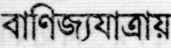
বাণিজ্যযাত্রায়
